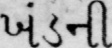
ખંડની
